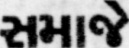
સમાજે
